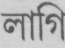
লাগি
